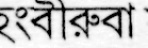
হংবীরুবা
